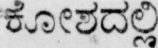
ಕೋಶದಲ್ಲಿ
